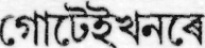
গোটেইখনৰে
